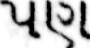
પણ
